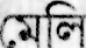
মেলি
